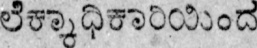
ಲೆಕ್ಕಾಧಿಕಾರಿಯಿಂದ
